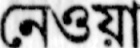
নেওয়া
